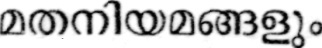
മതനിയമങ്ങളും
